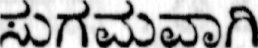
ಸುಗಮವಾಗಿ
